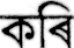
কৰি
